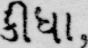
કીધા,
